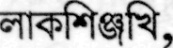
লাকশিঞ্জখি,
